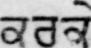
ਕਰਕੇ
